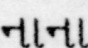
નાના
